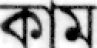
কাম
